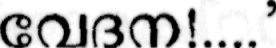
വേദന!....’
